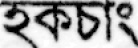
হকচাং
